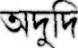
অদুদি
